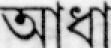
আধা
